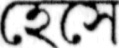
হেসে
